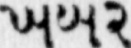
ખબર
